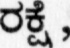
ರಕ್ಷೆ,
